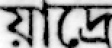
য়াদ্রে
